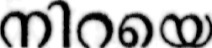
നിറയെ
